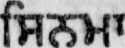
ਸਿਨਮਾ
